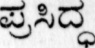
ಪ್ರಸಿದ್ಧ
